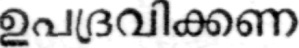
ഉപദ്രവിക്കണ
